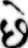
છે
